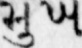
મુખ
